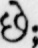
છે
